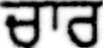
ਚਾਰ
